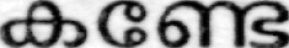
കണ്ടേ
